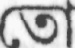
তো
